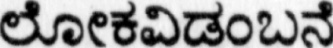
ಲೋಕವಿಡಂಬನೆ
